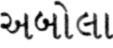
અબોલા
